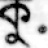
কু.
